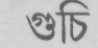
গুচি
